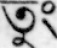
তুং
